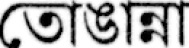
তোঙান্না
